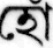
হোঁ
